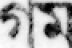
গম
